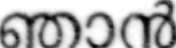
ഞാന്‍
